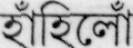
হাঁহিলোঁ
